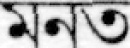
মনত
